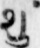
શું
